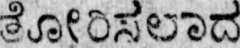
ತೋರಿಸಲಾದ
